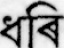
ধৰি
